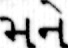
મને
